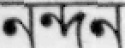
নন্দন
